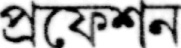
প্রফেশন
